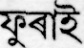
ফুৰাই
